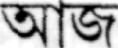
আজ
